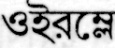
ওইরম্লে
